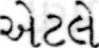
એટલે
